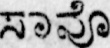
ಸಾವೊ
